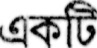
একটি
